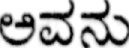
ಅವನು
